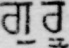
ਗੁਰੂ
